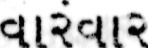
વારંવાર
